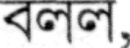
বলল,
